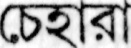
চেহারা
